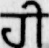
ਹੀ
